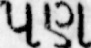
પણ
